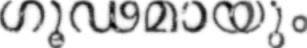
ഗൂഢമായും
